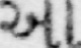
આ
